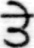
ਤੇ
